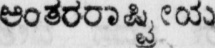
ಅಂತರರಾಷ್ಟ್ರೀಯ
